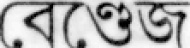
বেণ্ডেজ
